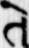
તે
